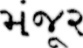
મંજૂર
